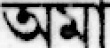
অমা
